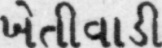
ખેતીવાડી
